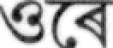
ওৰে
